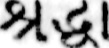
શ્રદ્ધા
